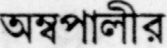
অম্বপালীর
